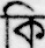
কি
